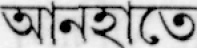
আনহাতে
